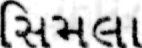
સિમલા
